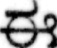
ಈ
